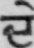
ਦੇ
